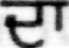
ਦਾ
